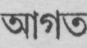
আগত
